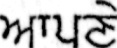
ਆਪਣੇ
